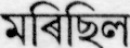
মৰিছিল
